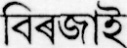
বিৰজাই
